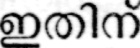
ഇതിന്
